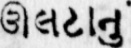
ઊલટાનું
